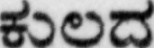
ಕುಲದ
